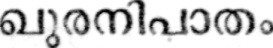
ഖുരനിപാതം
